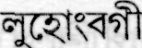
লুহোংবগী
